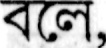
বলে,
